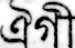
ঐগী
